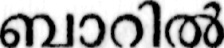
ബാറില്‍
